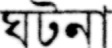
ঘটনা
